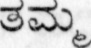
ತಮ್ಮ
